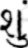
શું
